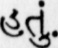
હતું.
